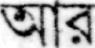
আর
